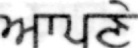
ਆਪਣੇ
